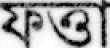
ফত্তা
